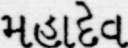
મહાદેવ
